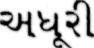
અધૂરી
